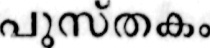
പുസ്തകം
